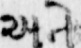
અને
